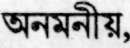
অনমনীয়,
